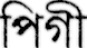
পিগী
